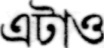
এটাও
